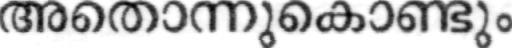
അതൊന്നുകൊണ്ടും
